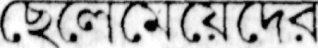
ছেলেমেয়েদের
